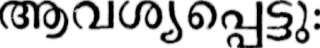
ആവശ്യപ്പെട്ടു:
